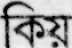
কিয়
